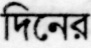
দিনের
